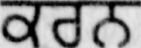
ਕਰਨ
